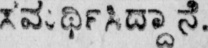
ಸಮರ್ಥಿಸಿದ್ದಾನೆ.
